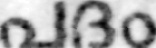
പദം
